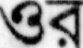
ওর
